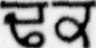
ਢਕ
